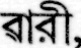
ৱারী,
